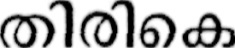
തിരികെ
